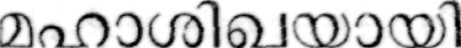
മഹാശിഖയായി
